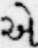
એ
